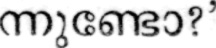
ന്നുണ്ടോ?'
